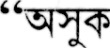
“অসুক
